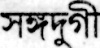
সঙ্গদুগী
